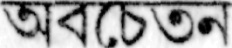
অবচেতন
